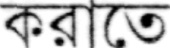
করাতে
